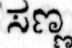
ಸಣ್ಣ
